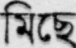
মিছে
